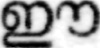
ഈ
